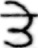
ਤੇ
